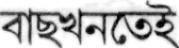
বাছখনতেই
